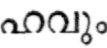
ഹവും
